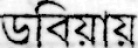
ডবিয়ায়
